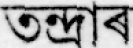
তন্দ্রাৰ
